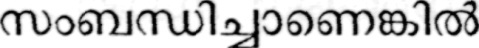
സംബന്ധിച്ചാണെങ്കില്‍
